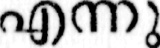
എന്നു
